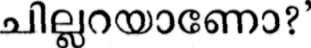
ചില്ലറയാണോ?’
